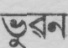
ভুৱন
